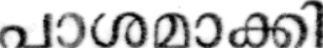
പാശമാക്കി
